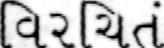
વિરચિતં
